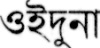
ওইদুনা
